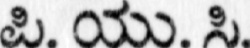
ಪಿ.ಯು.ಸಿ.
